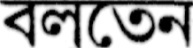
বলতেন
